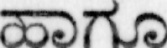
ಹಾಗೂ
